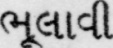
ભૂલાવી
